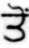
ਤੋਂ
